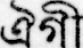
ঐগী
